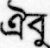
ঐবু
